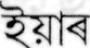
ইয়াৰ
